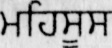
ਮਹਿਸੂਸ
